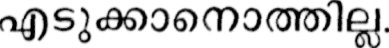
എടുക്കാനൊത്തില്ല.
